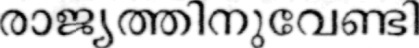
രാജ്യത്തിനുവേണ്ടി
